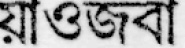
য়াওজবা
